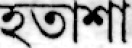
হতাশা
